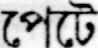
পেটে
